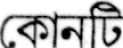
কোনটি
